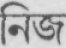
নিজ
